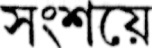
সংশয়ে
